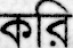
করি
